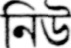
নিউ
